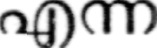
എന്ന
